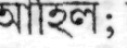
আহিল;
